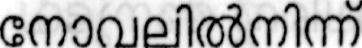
നോവലില്‍നിന്ന്
